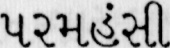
પરમહંસી
